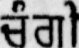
ਚੰਗੀ
